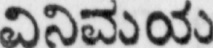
ವಿನಿಮಯ
